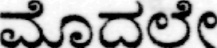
ಮೊದಲೇ
